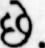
છે.
